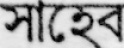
সাহেব
